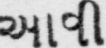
આવી
